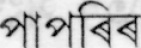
পাপৰিৰ
